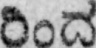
ರಿಂದ
